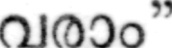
വരാം”
